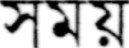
সময়
